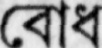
বোধ
